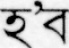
হ'ব
